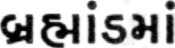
બ્રહ્માંડમાં
